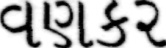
વણકર
